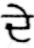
ਦੇ
